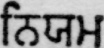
ਨਿਯਮ
